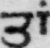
ਤਾਂ
